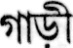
গাড়ী
